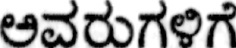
ಅವರುಗಳಿಗೆ
